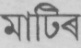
মাটিৰ
